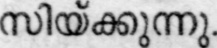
സിയ്ക്കുന്നു.
